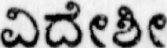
ವಿದೇಶೀ
